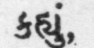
કહ્યું,
